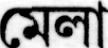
মেলা
